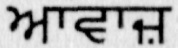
ਆਵਾਜ਼
